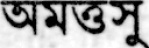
অমত্তসু
